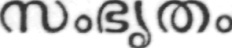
സംഭൃതം
